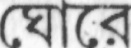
ঘোরে
